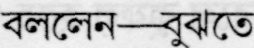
বললেন–বুঝতে
